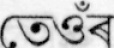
তেওঁৰ
